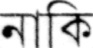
নাকি
